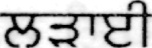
ਲੜਾਈ
